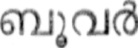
ബൂവര്‍
